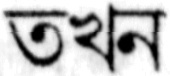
তখন
